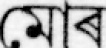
মোৰ
